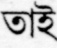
তাই
